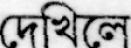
দেখিলে
